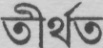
তীৰ্থত
